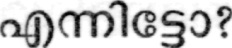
എന്നിട്ടോ?
